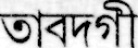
তাবদগী
